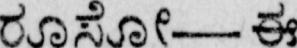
ರೂಸೋ-ಈ
